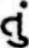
તું
